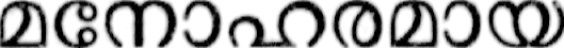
മനോഹരമായ
